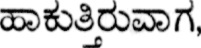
ಹಾಕುತ್ತಿರುವಾಗ,
